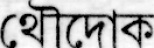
থৌদোক
